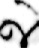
જે
